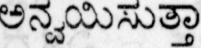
ಅನ್ವಯಿಸುತ್ತಾ
